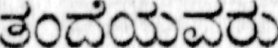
ತಂದೆಯವರು
